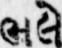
ભલે
